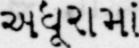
અધૂરામાં
